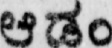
ಆಡ೦
